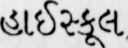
હાઈસ્કૂલ
